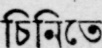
চিনিতে
